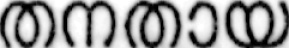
തനതായ
